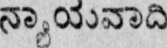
ನ್ಯಾಯವಾದಿ
